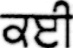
ਕਈ
